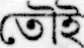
তৌই
